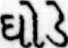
ઘોડે
